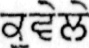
ਕੁਵੇਲੇ
